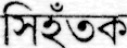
সিহঁতক
